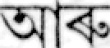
আৰু
